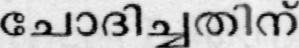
ചോദിച്ചതിന്
